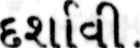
દર્શાવી.
